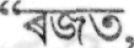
"ৰজত,
